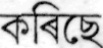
কৰিছে
